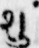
શું
